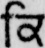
ਕਿ
